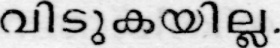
വിടുകയില്ല.
